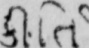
કીર્તિ
